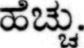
ಹೆಚ್ಚು.
